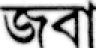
জবা
